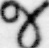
જ
